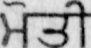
ਮੋਤੀ
